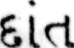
દાંત
